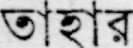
তাহার
